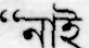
"নাই
